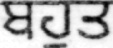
ਬਹੁਤ
